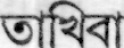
তাখিবা
